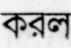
করল
